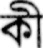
কী
